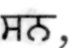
ਸਨ,
